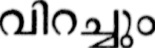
വിറച്ചും
